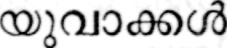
യുവാക്കള്‍
